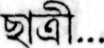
ছাত্রী...
